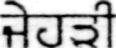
ਜੇਹੜੀ
